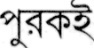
পুরকই
